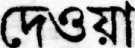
দেওয়া
